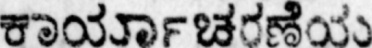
ಕಾರ್ಯಾಚರಣೆಯ
